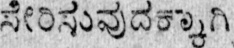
ಸೇರಿಸುವುದಕ್ಕಾಗಿ
